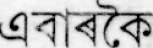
এবাৰকৈ
